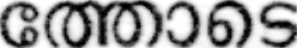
ത്തോടെ
